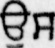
ਉਸ
